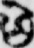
છે
